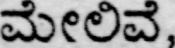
ಮೇಲಿವೆ,
